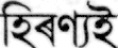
হিৰণ্যই
